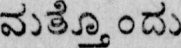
ಮತ್ತೊಂದು
